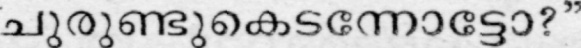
ചുരുണ്ടുകെടന്നോട്ടോ?"
